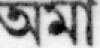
অমা
